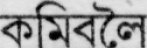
কমিবলৈ
